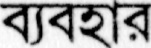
ব্যবহার
